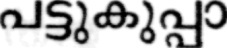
പട്ടുകുപ്പാ
